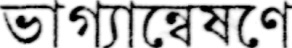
ভাগ্যান্বেষণে
